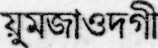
য়ুমজাওদগী
